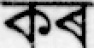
কৰ
